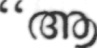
"'ആ
